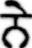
ਨੇ
